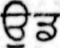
ਉਡ
